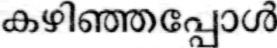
കഴിഞ്ഞപ്പോള്‍
